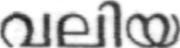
വലിയ
